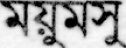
ময়ুমসু
